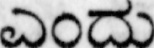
ಎಂದು
